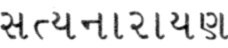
સત્યનારાયણ
